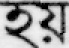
হয়
